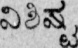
ವಿಶಿಷ್ಟ
